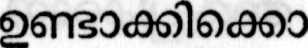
ഉണ്ടാക്കിക്കൊ
